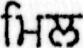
ਮਿਲ
